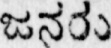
ಜನರು
